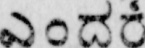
ಎಂದರೆ
